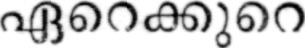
ഏറെക്കുറെ
